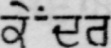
ਕੇਂਦਰ
